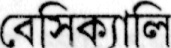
বেসিক্যালি
